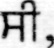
ਸੀ,
